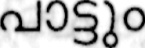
പാട്ടും
